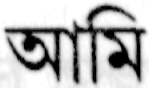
আমি
